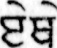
ਏਥੇ
